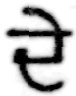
ਦੇ
